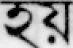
হয়
